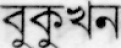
বুকুখন
